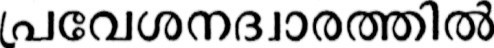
പ്രവേശനദ്വാരത്തില്‍
